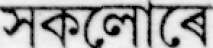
সকলোৰে
